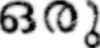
ഒരു
